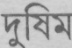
দুষিম
